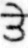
ਤੇ
